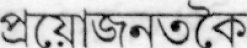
প্রয়োজনতকৈ
